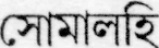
সোমালহি
